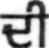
ਦੀ
